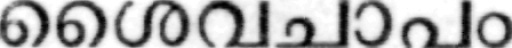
ശൈവചാപം
